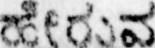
ಹೇರುವ
